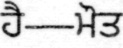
ਹੈ--ਮੌਤ
